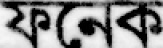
ফনেক
